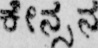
ಕೇನ್ಸನ
